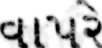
વાપરે
